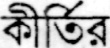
কীর্তির
